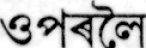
ওপৰলৈ
